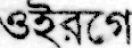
ওইরগে
